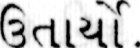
ઉતાર્યો.
